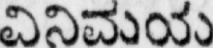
ವಿನಿಮಯ
